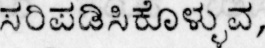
ಸರಿಪಡಿಸಿಕೊಳ್ಳುವ,
